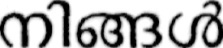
നിങ്ങള്‍
